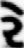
રે
